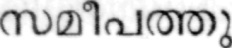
സമീപത്തു
